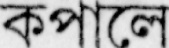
কপালে
